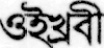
ওইখ্রবী
